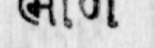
ભાળ
